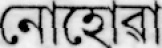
নোহোৱা
